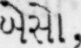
બેસો,
